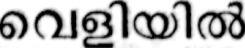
വെളിയില്‍
